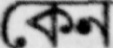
কেন
